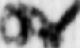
જ
